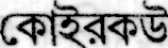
কোইরকউ
